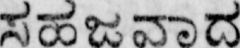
ಸಹಜವಾದ
